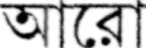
আরো
